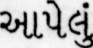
આપેલું
